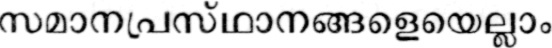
സമാനപ്രസ്ഥാനങ്ങളെയെല്ലാം
